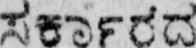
ಸರ್ಕಾರದ
